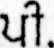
ਪੀ.
